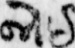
જોઈ
